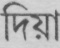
দিয়া
